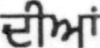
ਦੀਆਂ
